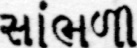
સાંભળી
